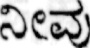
ನೀವು
